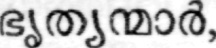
ഭൃത്യന്മാര്‍,
